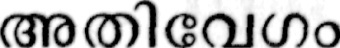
അതിവേഗം
